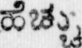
ಹೆಚ್ಚು
